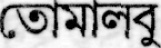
তোমালবু
